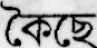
কৈছে
